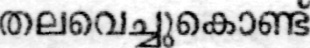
തലവെച്ചുകൊണ്ട്
